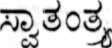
ಸ್ವಾತಂತ್ರ್ಯ
